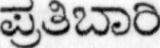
ಪ್ರತಿಬಾರಿ
